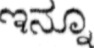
ಇನ್ನೂ
